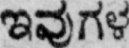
ಇವುಗಳ
